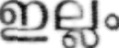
ഇല്ലം
